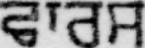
ਵਾਰਸ
